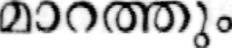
മാറത്തും
